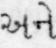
અને
